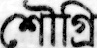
শৌগ্রি
